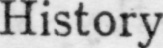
History
